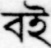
বই
